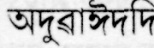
অদুৱাঈদদি
